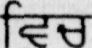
ਵਿਚ
